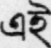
এই
